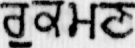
ਰੁਕਮਣ
